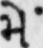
મેં
